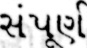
સંપૂર્ણ
